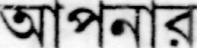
আপনার
